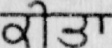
ਕੀਤਾ
